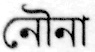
নৌনা
